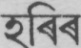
হৰিৰ
